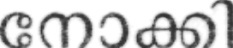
നോക്കി
